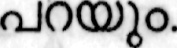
പറയും.
